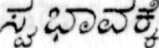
ಸ್ವಭಾವಕ್ಕೆ
